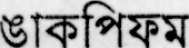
ঙাকপিফম
